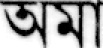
অমা
